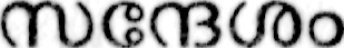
സന്ദേശം
